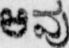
ಅವು
